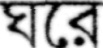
ঘরে
